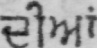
ਦੀਆਂ
